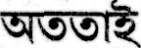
অততাই
